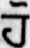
ਹੋ
